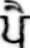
ਪੈ
